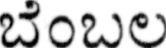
ಬೆಂಬಲ
